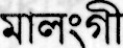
মালংগী
